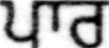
ਪਾਰ
